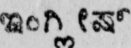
ಇಂಗ್ಲೀಷ್
